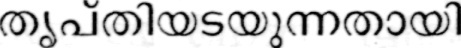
തൃപ്തിയടയുന്നതായി
